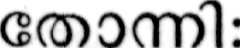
തോന്നി:
